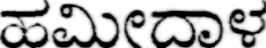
ಹಮೀದಾಳ
